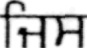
ਜਿਸ
